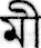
মী
